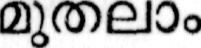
മുതലാം
